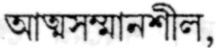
আত্মসম্মানশীল,
